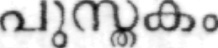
പുസ്തകം
